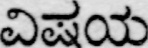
ವಿಷಯ
